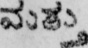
ಮತ್ತು
